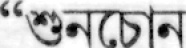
"শুনচোন
